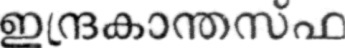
ഇന്ദ്രകാന്തസ്ഫ
